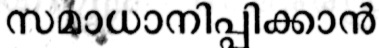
സമാധാനിപ്പിക്കാന്‍
